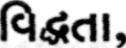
વિદ્ધતા,
